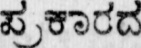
ಪ್ರಕಾರದ
